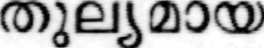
തുല്യമായ
